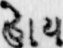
હોય
